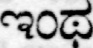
ಇಂಥ
